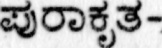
ಪುರಾಕೃತ -
